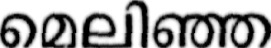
മെലിഞ്ഞ
